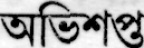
অভিশপ্ত
